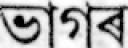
ভাগৰ
